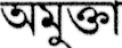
অমুক্তা
